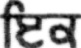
ਇਕ
